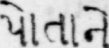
પોતાને
